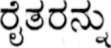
ರೈತರನ್ನು
